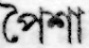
পৈশা
